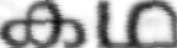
കഥ
